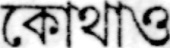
কোথাও
